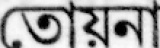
তোয়না
